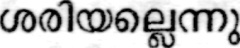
ശരിയല്ലെന്നു
